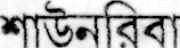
শাউনরিবা
